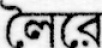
লৈরে
